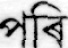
পৰি
